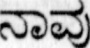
ನಾವು
